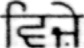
ਵਿਜ਼ੇ
